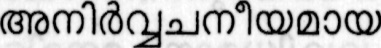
അനിര്‍വ്വചനീയമായ
